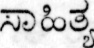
ಸಾಹಿತ್ಯ
